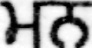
ਮਨ
